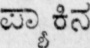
ಪ್ಯಾಕಿನ
